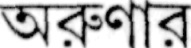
অরুণার
